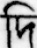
দি
